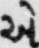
એ
